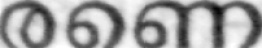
രണെ
